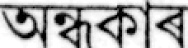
অন্ধকাৰ
